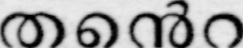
തന്റെ
